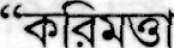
“করিমত্তা
